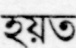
হয়ত
